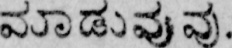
ಮಾಡುವುವು.
